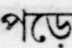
পড়ে
